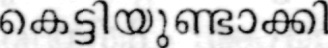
കെട്ടിയുണ്ടാക്കി
